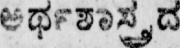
ಅರ್ಥಶಾಸ್ತ್ರದ
